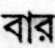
বার
